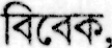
বিবেক,
